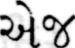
એજ
